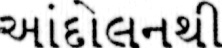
આંદોલનથી
